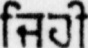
ਜਿਹੀ
